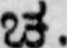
ಚ.
